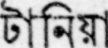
টানিয়া
